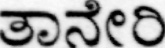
ತಾನೇರಿ
